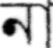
না
